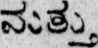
ಮತ್ತು
